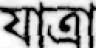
যাত্রা
